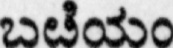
ಬೞಯಂ
